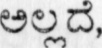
ಅಲ್ಲದೆ,
